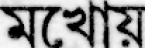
মখোয়
